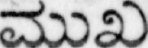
ಮುಖ
